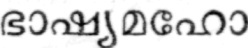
ഭാഷ്യമഹോ
